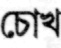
চোখ
